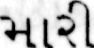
મારી
